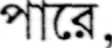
পারে,
